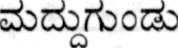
ಮದ್ದುಗುಂಡು
